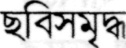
ছবিসমৃদ্ধ
